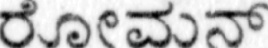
ರೋಮನ್
